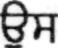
ਉਸ
